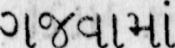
ગજવામાં
